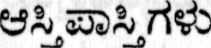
ಆಸ್ತಿಪಾಸ್ತಿಗಳು
